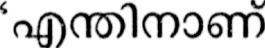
‘എന്തിനാണ്
